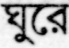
ঘুরে
